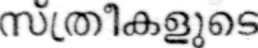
സ്ത്രീകളുടെ
